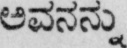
ಅವನನ್ನು
